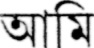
আমি
